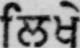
ਲਿਖੇ
